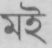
মই
